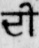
ਦੀ
